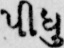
પીધુ
